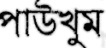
পাউখুম
